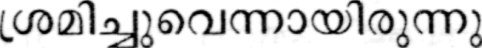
ശ്രമിച്ചുവെന്നായിരുന്നു
